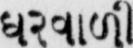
ઘરવાળી
